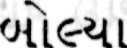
બોલ્યાં
